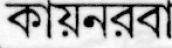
কায়নরবা
